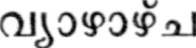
വ്യാഴാഴ്ച
